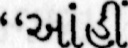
"આંહીં
